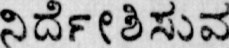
ನಿರ್ದೇಶಿಸುವ
